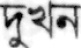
দুখন
